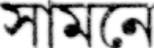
সামনে
